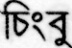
চিংবু
